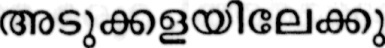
അടുക്കളയിലേക്കു
